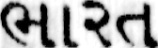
ભારત
